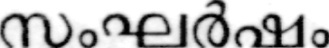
സംഘര്‍ഷം
